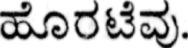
ಹೊರಟೆವು.
